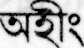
অহীং
